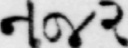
નજર
